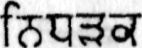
ਨਿਧੜਕ
